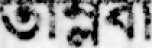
তাম্লবা
